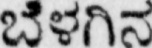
ಬೆಳಗಿನ
